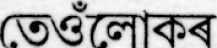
তেওঁলোকৰ
